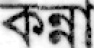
কন্না
